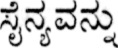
ಸೈನ್ಯವನ್ನು
